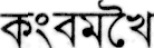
কংবমখৈ
